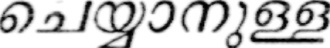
ചെയ്യാനുള്ള
